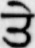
ਤੇ
